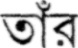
তাঁর
